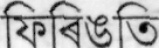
ফিৰিঙতি
